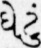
ઘેટું
